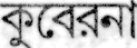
কুবেরনা
